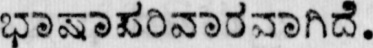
ಭಾಷಾಪರಿವಾರವಾಗಿದೆ.
